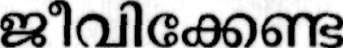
ജീവിക്കേണ്ട
